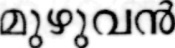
മുഴുവന്‍
